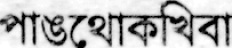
পাঙথোকখিবা
